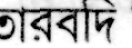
তারবদি
